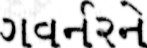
ગવર્નરને
